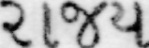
રાજ્ય
